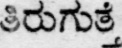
ತಿರುಗುತ್ತೆ
